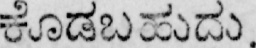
ಕೊಡಬಹುದು.
